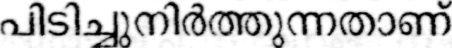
പിടിച്ചുനിര്‍ത്തുന്നതാണ്
